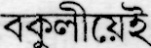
বকুলীয়েই
